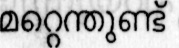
മറ്റെന്തുണ്ട്
